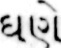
ઘણે
